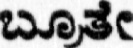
ಬ್ರೂತೇ
